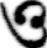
ও
